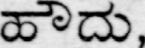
ಹೌದು,
